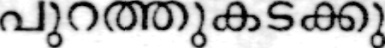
പുറത്തുകടക്കു
